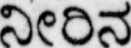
ನೀರಿನ
